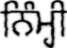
ਨਿੰਮ੍ਹੀ
